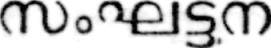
സംഘട്ടന
